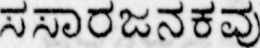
ಸಸಾರಜನಕವು
